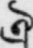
ঐ
